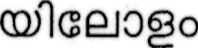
യിലോളം
